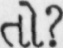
તો?
